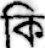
কি
